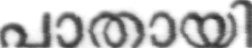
പാതായി
